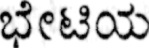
ಭೇಟಿಯ
